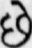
છે
